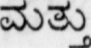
ಮತ್ತು
